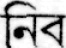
নিব
